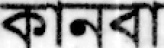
কানবা
